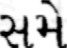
સમે
